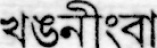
খঙনীংবা
